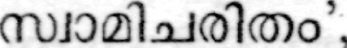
സ്വാമിചരിതം’,
